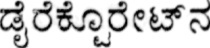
ಡೈರೆಕ್ಟೊರೇಟ್ ನ
